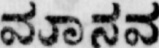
ಮಾನವ
